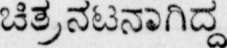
ಚಿತ್ರನಟನಾಗಿದ್ದ
